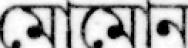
মোমোন
